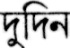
দুদিন
